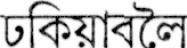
ঢকিয়াবলৈ
